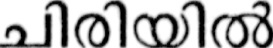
ചിരിയില്‍
